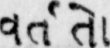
વર્તતો
